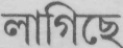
লাগিছে
